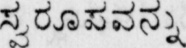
ಸ್ವರೂಪವನ್ನು
